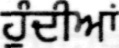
ਹੁੰਦੀਆਂ
